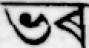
ভৰ
